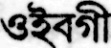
ওইবগী
